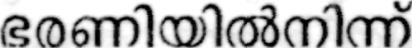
ഭരണിയില്‍നിന്ന്
